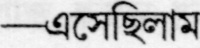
–এসেছিলাম
